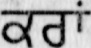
ਕਰਾਂ
